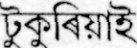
টুকুৰিয়াই
